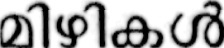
മിഴികള്‍
